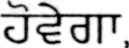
ਹੋਵੇਗਾ,
